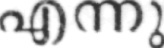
എന്നു
